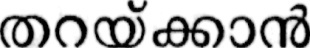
തറയ്ക്കാന്‍
